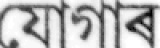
যোগাৰ
